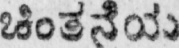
ಚಿಂತನೆಯ
